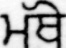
ਮੱਥੇ
